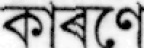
কাৰণে
